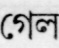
গেল
